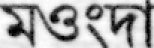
মওংদা
